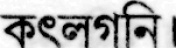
কৎলগনি।
